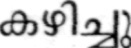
കഴിച്ചു
